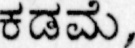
ಕಡಮೆ,
